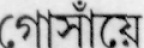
গোসাঁয়ে
